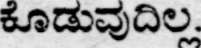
ಕೊಡುವುದಿಲ್ಲ.
